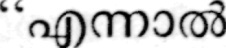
"എന്നാല്‍
